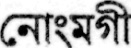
নোংমগী
